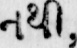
નથી,
